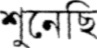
শুনেছি
